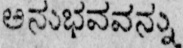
ಅನುಭವವನ್ನು
